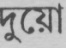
দুয়ো
